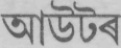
আউটৰ
